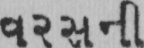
વરસની
